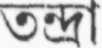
তন্দ্রা
